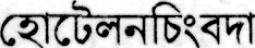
হোটেলনচিংবদা
